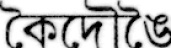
কৈদৌঙৈ
